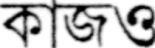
কাজও
